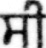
ਸੀ
